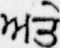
ਅਤੇ
